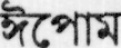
ঈপোম
